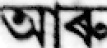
আৰু
